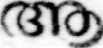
ആ
